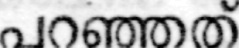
പറഞ്ഞത്
